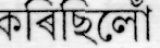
কৰিছিলোঁ
